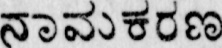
ನಾಮಕರಣ
